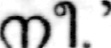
നീ.'
